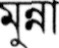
মুন্না
